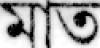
মাত
